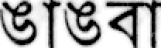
ঙাঙবা
